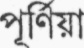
পূর্ণিয়া
